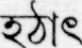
হঠাৎ
